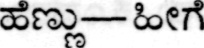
ಹೆಣ್ಣು-ಹೀಗೆ
